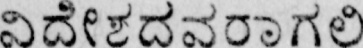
ವಿದೇಶದವರಾಗಲಿ
